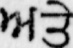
ਅਤੇ
